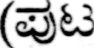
(ಪುಟ
